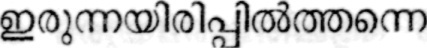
ഇരുന്നയിരിപ്പില്‍ത്തന്നെ
